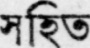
সহিত
